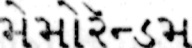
મેમોરૅન્ડમ
